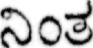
ನಿಂತ
